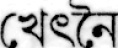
খেৎনৈ
